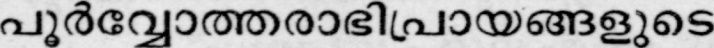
പൂര്‍വ്വോത്തരാഭിപ്രായങ്ങളുടെ
